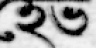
হেভ
